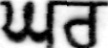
ਘਰ
